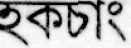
হকচাং
